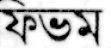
ফিভম
